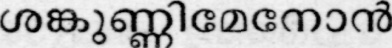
ശങ്കുണ്ണിമേനോന്‍
